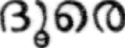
ദൂരെ
